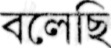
বলেছি
